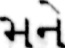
મને
